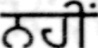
ਨਹੀਂ
